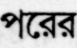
পরের
